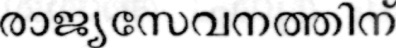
രാജ്യസേവനത്തിന്
